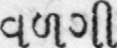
વળગી
